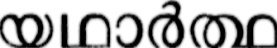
യഥാര്‍ത്ഥ
